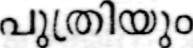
പുത്രിയും
